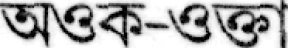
অওক-ওক্তা
